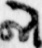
જો
